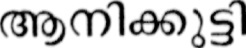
ആനിക്കുട്ടി
